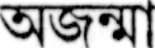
অজন্মা
